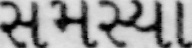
સમસ્યા
